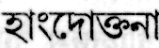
হাংদোক্তনা
